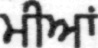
ਮੀਆਂ
